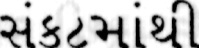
સંકટમાંથી
